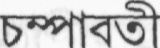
চম্পাবতী
